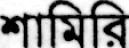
শামিরি
